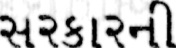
સરકારની
